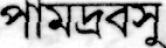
পামদ্রবসু
